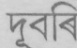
দূবৰি
